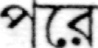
পরে
